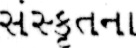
સંસ્કૃતના
